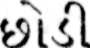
છોડી
